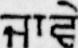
ਜਾਵੇ
